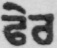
ਫੇਰ
